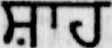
ਸ਼ਾਹ
